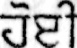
ਹੋਈ
